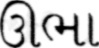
ઊભા
